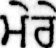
ਮੇਰੇ
